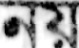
নয়
